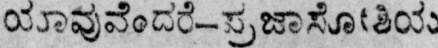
ಯಾವುವೆಂದರೆ-ಪ್ರಜಾಸೋಶಿಯ
